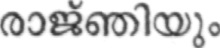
രാജ്ഞിയും
